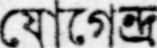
যোগেন্দ্র
